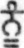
ਨੂੰ
